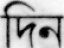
দিন
